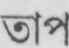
তাপ
